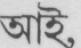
আই,
